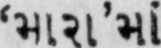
'મારા'માં
